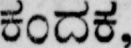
ಕಂದಕ,
